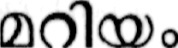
മറിയം
